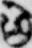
છે
